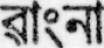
ৱাংনা
